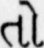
તો
